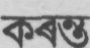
কৰন্ত
